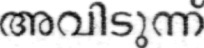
അവിടുന്ന്
